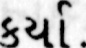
કર્યા.
